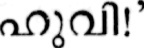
ഹുവി!’
